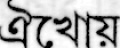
ঐখোয়
